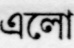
এলো
